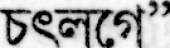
চৎলগে”
